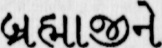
બ્રહ્માજીને
